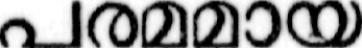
പരമമായ
